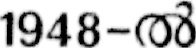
1948-ല്‍
